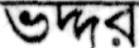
ভদ্দর
